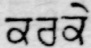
ਕਰਕੇ
